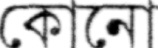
কোনো
